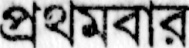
প্রথমবার
